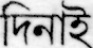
দিনাই
